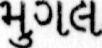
મુગલ
